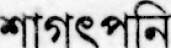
শাগৎপনি
